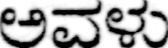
ಅವಳು
